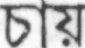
চায়
